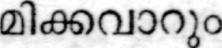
മിക്കവാറും
